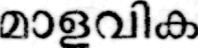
മാളവിക
